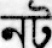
নট
